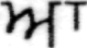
ਆ
